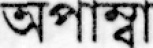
অপাম্বা
